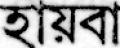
হায়বা
